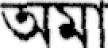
অমা
